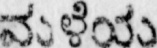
ಮಳೆಯ
